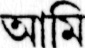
আমি
